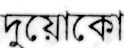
দুয়োকো
